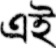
এই
